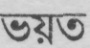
ভয়ত
